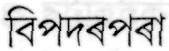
বিপদৰপৰা
